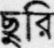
ছুরি
